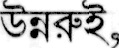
উন্নরুই,
